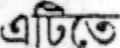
এটিতে
